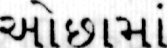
ઓછામાં
